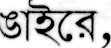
ঙাইরে,
